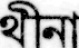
থীনা
